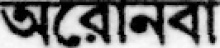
অরোনবা
